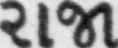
રાજા
